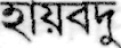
হায়বদু
